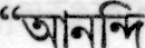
“আনন্দি
